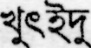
খুৎইদু
